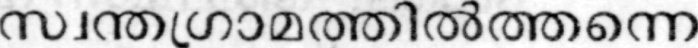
സ്വന്തഗ്രാമത്തില്‍ത്തന്നെ
